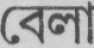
বেলা
